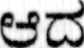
ಆದ
